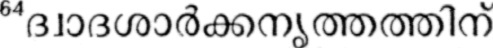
64ദ്വാദശാര്‍ക്കനൃത്തത്തിന്
